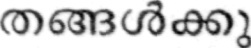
തങ്ങള്‍ക്കു
